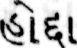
હોદ્દા
